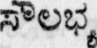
ಸೌಲಭ್ಯ
